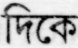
দিকে
